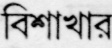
বিশাখার
